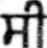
ਸੀ
